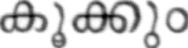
കൂക്കും
